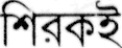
শিরকই
